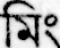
মিং
